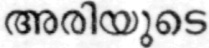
അരിയുടെ
